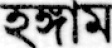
হঙ্গাম
